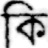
কি
